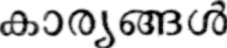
കാര്യങ്ങള്‍
